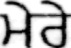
ਮੇਰੇ
